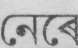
নেৰে
